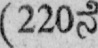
(220ನೆ
